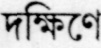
দক্ষিণে
